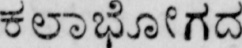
ಕಲಾಭೋಗದ
